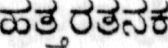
ಹತ್ತರತನಕ
